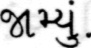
જામ્યું.
